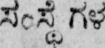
ಸಂಸ್ಥೆಗಳ
